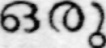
ഒരു
